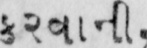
કરવાની,
